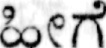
ಹೀಗೆ
